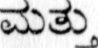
ಮತ್ತು
